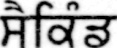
ਸੈਕਿੰਡ
